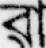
ৱা
